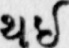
થઈ
